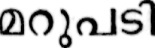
മറുപടി
